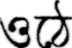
ওঠে
